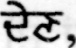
ਦੇਣ,
